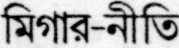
মিগার-নীতি
